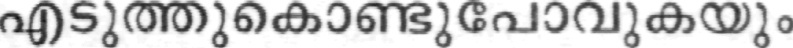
എടുത്തുകൊണ്ടുപോവുകയും
